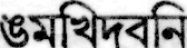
ঙমখিদবনি
